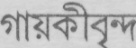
গায়কীবৃন্দ
